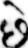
છે
